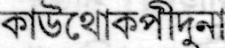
কাউথোকপীদুনা
